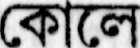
কোলে
